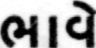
ભાવે
